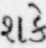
શકે
